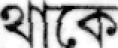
থাকে
